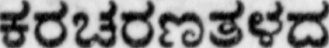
ಕರಚರಣತಳದ
